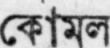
কোমল
